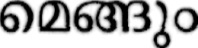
മെങ്ങും
